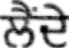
ਲੈਂਦੇ
